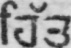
ਹਿੱਤ
